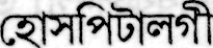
হোসপিটালগী
